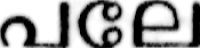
പലേ
